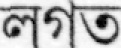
লগত
